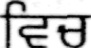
ਵਿਚ
